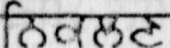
ਨਿਕਲਣ
